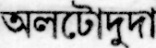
অলটোদুদা
